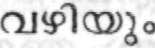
വഴിയും
